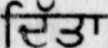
ਦਿੱਤਾ
